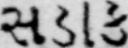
સડાક
